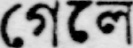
গেলে
